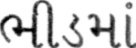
ભીડમાં
